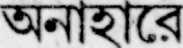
অনাহারে
